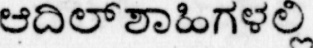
ಆದಿಲ್‌ಶಾಹಿಗಳಲ್ಲಿ
